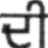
ਦੀ
